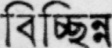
বিচ্ছিন্ন
